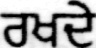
ਰਖਦੇ
